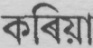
কৰিয়া
